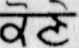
ਕੋਣੇ
